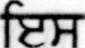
ਇਸ
